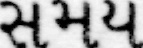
સમય
